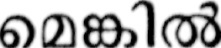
മെങ്കില്‍
